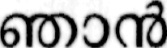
ഞാന്‍
